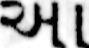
આ
